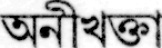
অনীখক্তা
